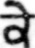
ਕੇ
